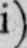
i)
